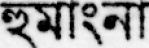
হুমাংনা
